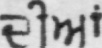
ਦੀਆਂ
